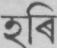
হৰি
